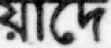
য়াদে
